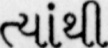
ત્યાંથી
